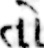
તો
